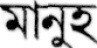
মানুহ
